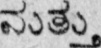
ಮತ್ತು
